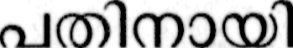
പതിനായി
